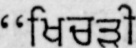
''ਖਿਚੜੀ
